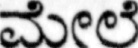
ಮೇಲೆ
